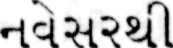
નવેસરથી
